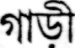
গাড়ী
